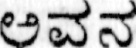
ಅವನ
